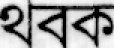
থবক
